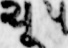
ચૂપ
